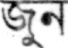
জুন
